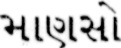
માણસો
